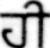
ਹੀ
